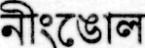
নীংঙোল
